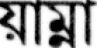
য়াম্না
